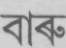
বাৰু
